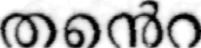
തന്റെ
